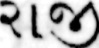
રાજી
